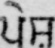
ਪੇਸ਼
